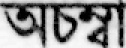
অচম্বা
